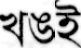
খঙই
